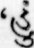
'હું
